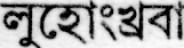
লুহোংখ্রবা
